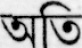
অতি
